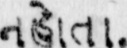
નહોતા.
